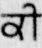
ਕੀ
